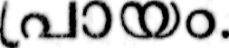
പ്രായം.
